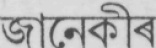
জানেকীৰ
